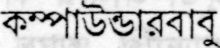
কম্পাউন্ডারবাবু
